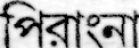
পিরাংনা
